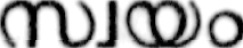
സ്വയം
